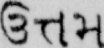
ઉત્તમ
